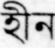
হীন
